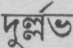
দুৰ্ল্লভ
